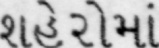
શહેરોમાં
